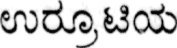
ಉರ್ರೂಟಿಯ
